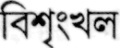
বিশৃংখল
